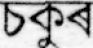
চকুৰ
